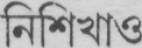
নিশিখাও
